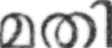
മതി
